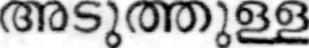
അടുത്തുള്ള
